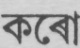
কৰো
